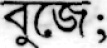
বুজে;
